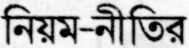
নিয়ম-নীতির
